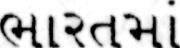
ભારતમાં
